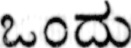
ಒಂದು
